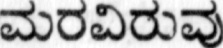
ಮರವಿರುವು
